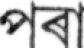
পৰা
